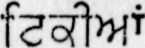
ਟਿਕੀਆਂ
